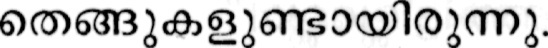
തെങ്ങുകളുണ്ടായിരുന്നു.
